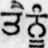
ਤੈਨੂੰ
